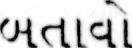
બતાવો
